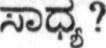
ಸಾಧ್ಯ?
